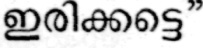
ഇരിക്കട്ടെ"
